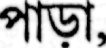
পাড়া,
